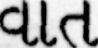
વાત
